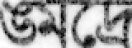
ঙমদ্রে
